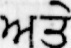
ਅਤੇ
